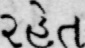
રહેત
